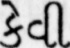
કેવી
